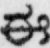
ಈ
